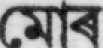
মোৰ
